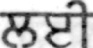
ਲਈ
